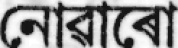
নোৱাৰো
